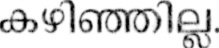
കഴിഞ്ഞില്ല.
